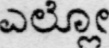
ಎಲ್ಲೋ
